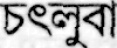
চৎলুবা
